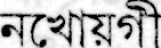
নখোয়গী
